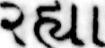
રહ્યા
